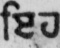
ਇਹ
